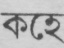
কহে
